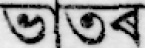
ভাতৰ
